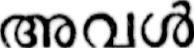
അവള്‍
